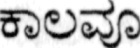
ಕಾಲವೂ
